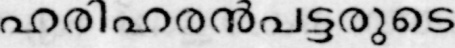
ഹരിഹരന്‍പട്ടരുടെ
